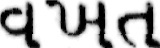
વખત
